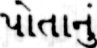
પોતાનું
